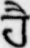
ਹੈ
